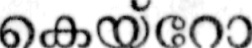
കെയ്റോ
